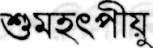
শুমহৎপীয়ু
